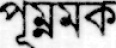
পূম্নমক
